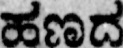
ಹಣದ
